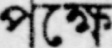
পক্ষে
